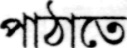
পাঠাতে
